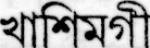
খাশিমগী
